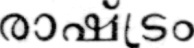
രാഷ്ട്രം
